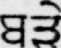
ਬੜੇ
